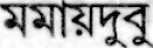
মমায়দুবু
